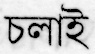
চলাই
